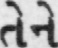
તેને
